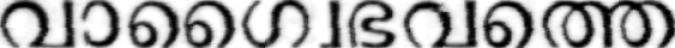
വാഗ്വൈഭവത്തെ
